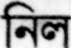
নিল
